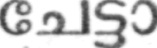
ചേട്ടാ
